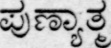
ಪುಣ್ಯಾತ್ಮ
